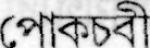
পোকচবী
